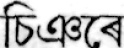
চিঞৰে
